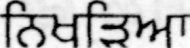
ਨਿਖੜਿਆ
